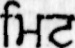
ਮਿਟ
